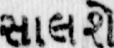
સાલશે
